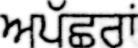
ਅਪੱਛਰਾਂ
